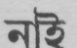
নাই
